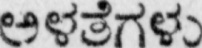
ಅಳತೆಗಳು
